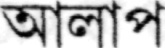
আলাপ
